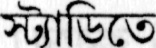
স্ট্যাডিতে
